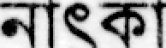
নাৎকা
